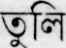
তুলি
